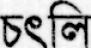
চৎলি
